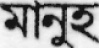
মানুহ
